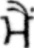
ਮੈਂ
